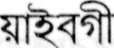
য়াইবগী
